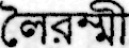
লৈরম্মী
